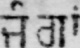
ਜੰਗਾਂ
